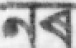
নৰ
